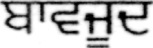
ਬਾਵਜੂਦ
